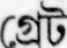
গ্ৰেট
